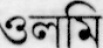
ওলমি
